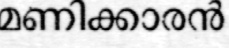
മണിക്കാരന്‍
